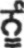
ਨੂੰ
